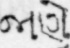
જાણે
